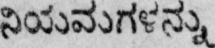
ನಿಯಮಗಳನ್ನು
